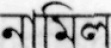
নামিল
